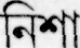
নিশা
